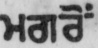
ਮਗਰੋਂ
